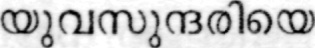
യുവസുന്ദരിയെ
